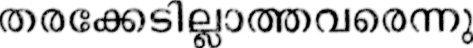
തരക്കേടില്ലാത്തവരെന്നു
